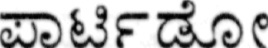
ಪಾರ್ಟಿಡೋ
